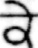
ਕੇ
